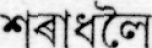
শৰাধলৈ
